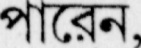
পারেন,
